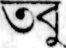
তবু
